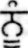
ਨੂੰ
